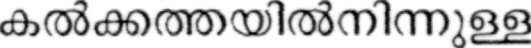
കല്‍ക്കത്തയില്‍നിന്നുള്ള
